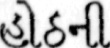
હોઠની
